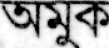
অমুক
